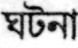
ঘটনা
